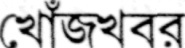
খোঁজখবর
